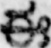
ಈ
